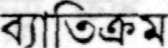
ব্যতিক্রম
